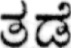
ತಡೆ
